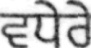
ਵਧੇਰੇ
